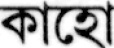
কাহো
